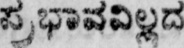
ಪ್ರಭಾವವಿಲ್ಲದ
